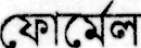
ফোর্মেল
